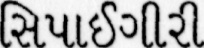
સિપાઈગીરી
